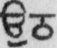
ਉਠ
